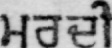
ਮਰਦੀ
